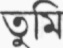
তুমি
